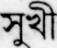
সুখী
